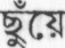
ছুঁয়ে
